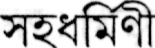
সহধর্মিণী
